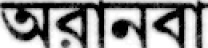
অরানবা
